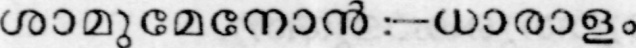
ശാമുമേനോന്‍:-ധാരാളം
